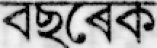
বছৰেক
